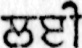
ਲਈ
